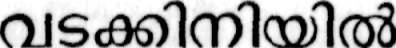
വടക്കിനിയില്‍
